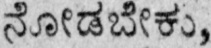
ನೋಡಬೇಕು,
